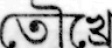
তৌখ্রে
